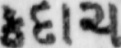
,કદાચ
